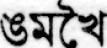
ঙমখৈ
